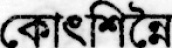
কোৎশিন্নৈ
